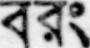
বরং
